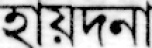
হায়দনা
